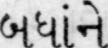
બધાંને
